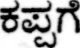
ಕಪ್ಪಗೆ
